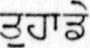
ਤੁਹਾਡੇ
